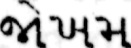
જોખમ
